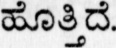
ಹೊತ್ತಿದೆ.
